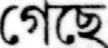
গেছে
